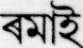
ৰমাই
